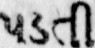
પડતી
